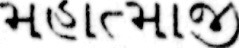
મહાત્માજી
